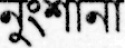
নুংশানা
